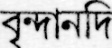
বৃন্দানদি
